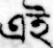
এই
